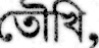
তৌখি,
